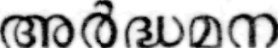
അര്‍ദ്ധമന
